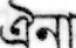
ঐনা
